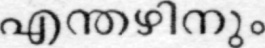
എന്തഴിനും
